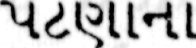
પટણાના
